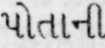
પોતાની
